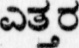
ಎತ್ತರ
